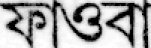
ফাওবা
